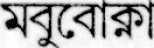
মবুবোক্না
